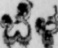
ಬೆಳ
